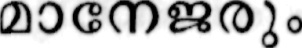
മാനേജരും
